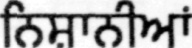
ਨਿਸ਼ਾਨੀਆਂ
